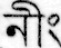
নীং
